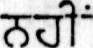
ਨਹੀਂ
